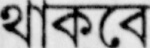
থাকবে
